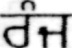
ਰੰਜ
